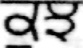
ਕੁਝ
